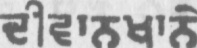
ਦੀਵਾਨਖਾਨੇ
